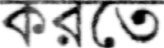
করতে
